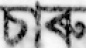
চাৰু
